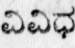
ವಿವಿಧ
